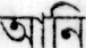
আনি
